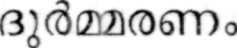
ദുര്‍മ്മരണം
